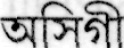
অসিগী
